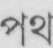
পথ
